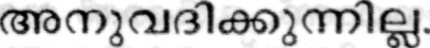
അനുവദിക്കുന്നില്ല.
